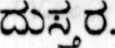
ದುಸ್ತರ.
